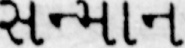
સન્માન
